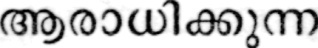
ആരാധിക്കുന്ന
